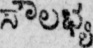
ಸೌಲಭ್ಯ
